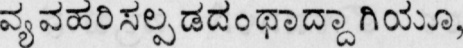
ವ್ಯವಹರಿಸಲ್ಪಡದಂಥಾದ್ದಾಗಿಯೂ,
